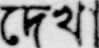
দেখা
